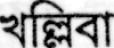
খল্লিবা
